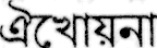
ঐখোয়না
